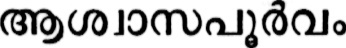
ആശ്വാസപൂര്‍വം
